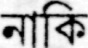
নাকি
